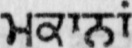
ਮਕਾਨਾਂ
